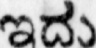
ಇದು
